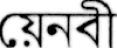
য়েনবী
